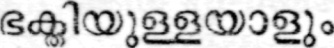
ഭക്തിയുള്ളയാളും
